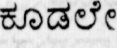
ಕೂಡಲೇ
